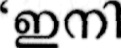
‘ഇനി
